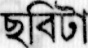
ছবিটা
